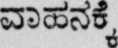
ವಾಹನಕ್ಕೆ
